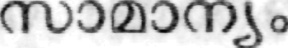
സാമാന്യം
